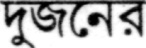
দুজনের
